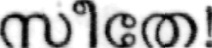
സീതേ!
